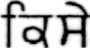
ਕਿਸੇ
